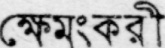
ক্ষেমংকরী
